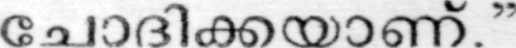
ചോദിക്കയാണ്.''
